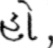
હો,
